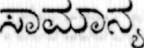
ಸಾಮಾನ್ಯ
